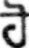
ਹੋ
